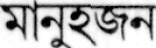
মানুহজন
